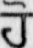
ਹੋ
